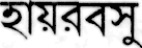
হায়রবসু
